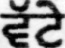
ਵੱਟੇ
